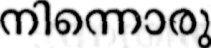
നിന്നൊരു
